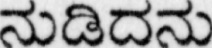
ನುಡಿದನು
